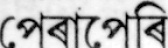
পেৰাপেৰি
